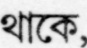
থাকে,
